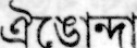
ঐঙোন্দা
